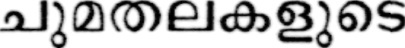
ചുമതലകളുടെ
